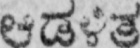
ಆಡಳಿತ
